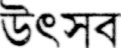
উত্সব
